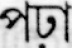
পঢ়া
